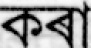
কৰা
